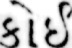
કોઇ
